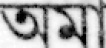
অমা
